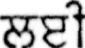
ਲਈ
